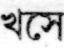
খসে
